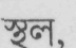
স্থল,
